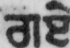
ਗਏ
